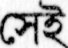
সেই
